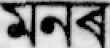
মনৰ
